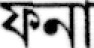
ফনা
